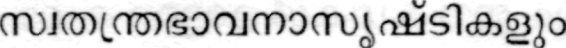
സ്വതന്ത്രഭാവനാസൃഷ്ടികളും
